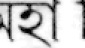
অহা
